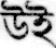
উই
